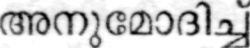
അനുമോദിച്ച്
